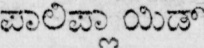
ಪಾಲಿಪ್ಲಾಯಿಡ್
